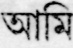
আমি
